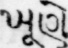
ખૂણે
